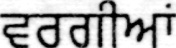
ਵਰਗੀਆਂ
